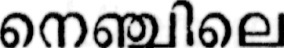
നെഞ്ചിലെ
